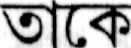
তাকে
